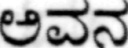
ಅವನ
